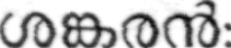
ശങ്കരന്‍:
